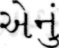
એનું
